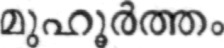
മുഹൂര്‍ത്തം
